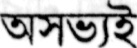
অসভ্যই
